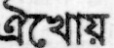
ঐখোয়
